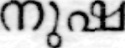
നുഷ
